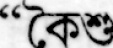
“কৈশু
